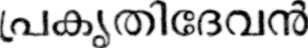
പ്രകൃതിദേവന്‍
